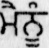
ਮੈਨੂੰ
